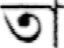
তা
